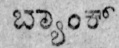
ಬ್ಯಾಂಕ್
